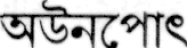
অউনপোৎ
